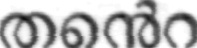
തന്റെ
